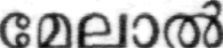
മേലാല്‍
